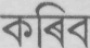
কৰিব
